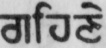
ਗਹਿਣੇ
